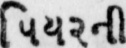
પિયરની
